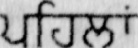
ਪਹਿਲਾਂ
